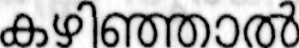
കഴിഞ്ഞാല്‍
